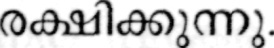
രക്ഷിക്കുന്നു.
